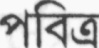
পবিত্র
